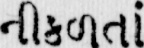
નીકળતાં
